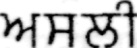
ਅਸਲੀ
